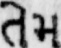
તેમ
